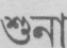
শুনা
